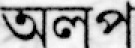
অলপ
